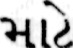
માટે
